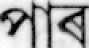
পাৰ
